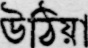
উঠিয়া
